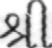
શ્રી
